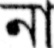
না
